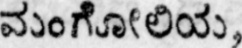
ಮಂಗೋಲಿಯ,
